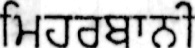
ਮਿਹਰਬਾਨੀ
